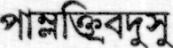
পাম্লক্ত্রিবদুসু
